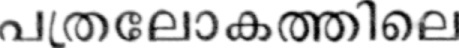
പത്രലോകത്തിലെ
